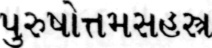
પુરુષોત્તમસહસ્ત્ર
